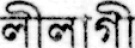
লীলাগী
